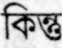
কিন্তু
